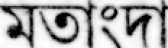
মতাংদা
